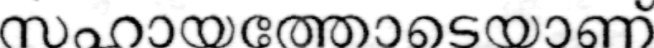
സഹായത്തോടെയാണ്
